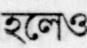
হলেও
